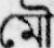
মৌ
